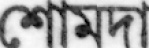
শোমদা
